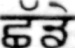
ਛੱਡੇ
